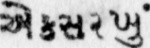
એકસરખું
